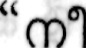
"നീ
